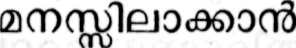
മനസ്സിലാക്കാന്‍
